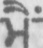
ਮੈਂ
